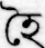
হৈ
